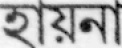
হায়না
